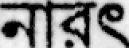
নারৎ
